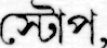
স্টোপ,
